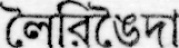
লৈরিঙৈদা
